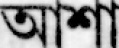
আশা
